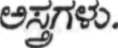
ಅಸ್ತ್ರಗಳು.
